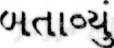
બતાવ્યું
